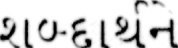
શબ્દાર્થને
